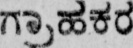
ಗ್ರಾಹಕರ
